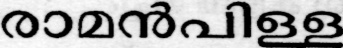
രാമന്‍പിള്ള
